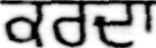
ਕਰਦਾ
